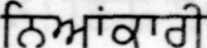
ਨਿਆਂਕਾਰੀ
